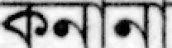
কনানা
